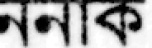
ননাক
